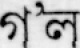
গ'ল
